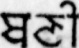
ਬਣੀ
